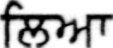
ਲਿਆ
